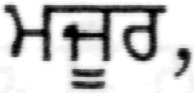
ਮਜੂਰ,
